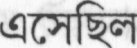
এসেছিল
